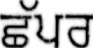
ਛੱਪਰ
